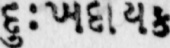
દુઃખદાયક
